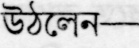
উঠলেন–
